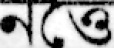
নত্তে
